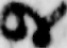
જ
